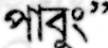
পাবুং”
